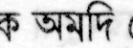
অমদি
